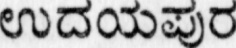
ಉದಯಪುರ
